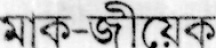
মাক-জীয়েক
